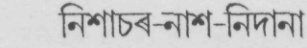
নিশাচৰ-নাশ-নিদানা
